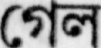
গেল
